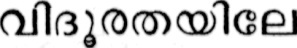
വിദൂരതയിലേ
